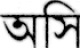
অসি
